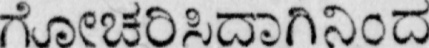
ಗೋಚರಿಸಿದಾಗಿನಿಂದ
